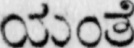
ಯಂತೆ
